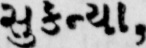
સુકન્યા
